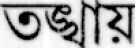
তঙ্খায়
